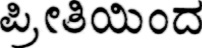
ಪ್ರೀತಿಯಿಂದ
